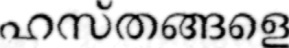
ഹസ്തങ്ങളെ
